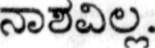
ನಾಶವಿಲ್ಲ.
